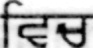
ਵਿਚ
